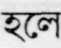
হলে
